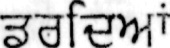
ਡਰਦਿਆਂ
